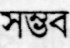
সম্ভব
